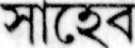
সাহেব
